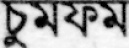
চুমফম
